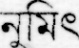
নুমিৎ
